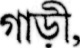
গাড়ী,
